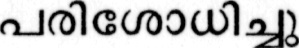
പരിശോധിച്ചു
